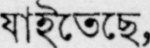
যাইতেছে,
